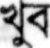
খুব
